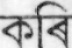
কৰি
